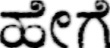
ಹೇಗೆ
